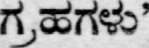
ಗ್ರಹಗಳು’
